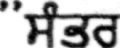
''ਸੰਭਰ
